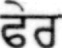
ਫੇਰ
